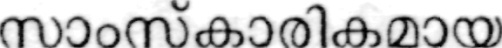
സാംസ്കാരികമായ
